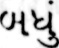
બધું
